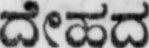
ದೇಹದ
